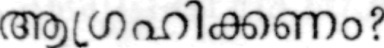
ആഗ്രഹിക്കണം?
